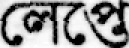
লেপ্তে
